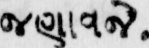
જણાવજે.
